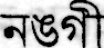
নঙগী
